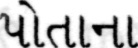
પોતાના
